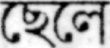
ছেলে
